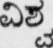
ವಿಶ್ವ
